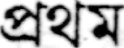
প্রথম
